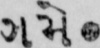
ગમે.
